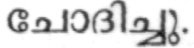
ചോദിച്ചു.
